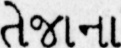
તેજાના
